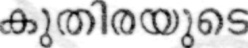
കുതിരയുടെ
